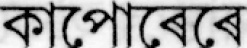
কাপোৰেৰে
